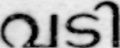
വടി
